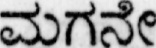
ಮಗನೇ
